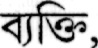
ব্যক্তি,
